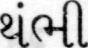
થંભી
